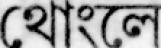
থোংলে
